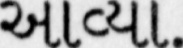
આવ્યા.
